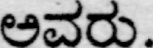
ಅವರು.
